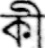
কী
